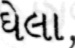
ઘેલા,
